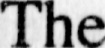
The
